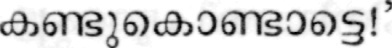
കണ്ടുകൊണ്ടാട്ടെ!'
